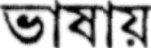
ভাষায়
